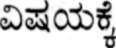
ವಿಷಯಕ್ಕೆ
